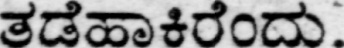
ತಡೆಹಾಕಿರೆಂದು.
